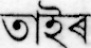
তাইৰ
